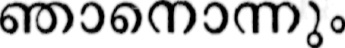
ഞാനൊന്നും
